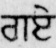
ਗਏ
